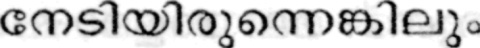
നേടിയിരുന്നെങ്കിലും
